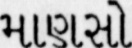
માણસો
